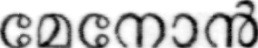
മേനോന്‍
